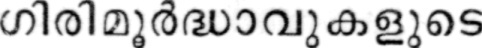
ഗിരിമൂര്‍ദ്ധാവുകളുടെ
